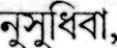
নুসুধিবা,
